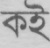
কই
